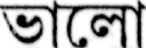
ভালো
